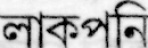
লাকপনি
